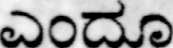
ಎಂದೂ
